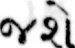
જશે
